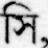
সি,
